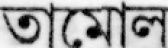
তামোল
